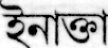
ইনাক্তা
